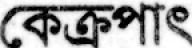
কেক্রুপাৎ
